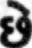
છે
